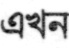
এখন
